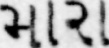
મારા
